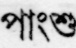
পাংশু
